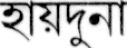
হায়দুনা
